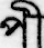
পী
